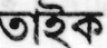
তাইক
